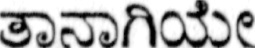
ತಾನಾಗಿಯೇ
